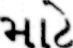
માટે
